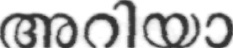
അറിയാ
